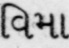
વિમા
